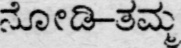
ನೋಡಿ-ತಮ್ಮ
